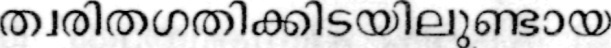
ത്വരിതഗതിക്കിടയിലുണ്ടായ
